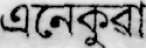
এনেকুৱা
